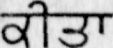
ਕੀਤਾ
